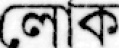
লোক
